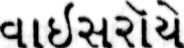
વાઇસરૉયે
